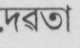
দেৱতা
